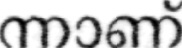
ന്നാണ്
